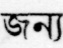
জন্য
